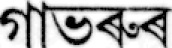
গাভৰুৰ
